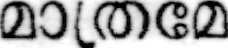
മാത്രമേ
